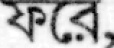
ফরে,
